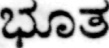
ಭೂತ
